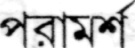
পরামর্শ
